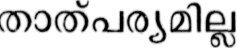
താത്പര്യമില്ല
